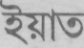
ইয়াত
